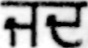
ਜਦ
